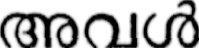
അവള്‍
